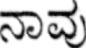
ನಾವು
